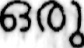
ഒരു
